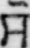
ਸੋ
